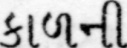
કાળની
